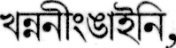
খন্ননীংঙাইনি,
